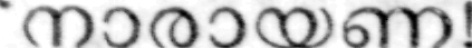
നാരായണ!
